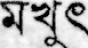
মখুৎ
